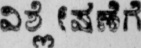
ವಿಶ್ಲೇಷಣೆಗೆ
